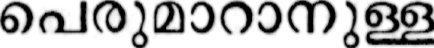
പെരുമാറാനുള്ള
